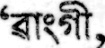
‘ৱাংগী,
